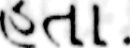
હતા.
